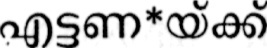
എട്ടണ*യ്ക്ക്
